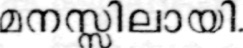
മനസ്സിലായി.
